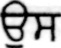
ਉਸ
